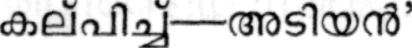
കല്പിച്ച്-അടിയന്‍'
